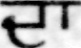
ਦਾ
